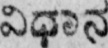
ವಿಧಾನ
